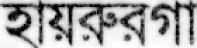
হায়রুরগা
